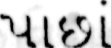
પાછાં
